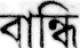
বান্ধি
